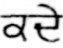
ਕਦੇ
